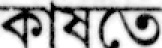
কাষতে
